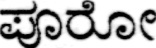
ಪೂರೋ
